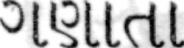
ગણાતા
